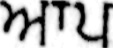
ਆਪ
